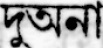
দুঅনা
